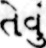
તેવું
